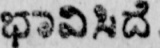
ಭಾವಿಸಿದೆ
